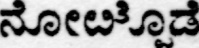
ನೋೞ್ಪೊಡೆ
